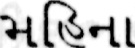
મહિના
